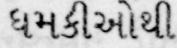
ધમકીઓથી
